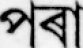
পৰা
